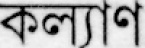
কল্যাণ
